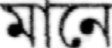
মানে
